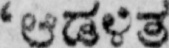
‘ಆಡಳಿತ
